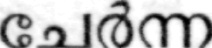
ചേര്‍ന്ന
